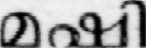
മഷി
